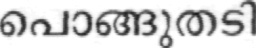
പൊങ്ങുതടി
